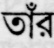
তাঁর
